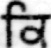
ਕਿ
